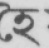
হৈ
